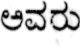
ಅವರು
